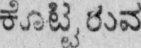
ಕೊಟ್ಟಿರುವ
